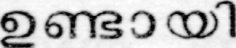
ഉണ്ടായി
